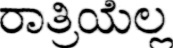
ರಾತ್ರಿಯೆಲ್ಲ
